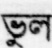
ভুল
